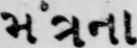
મંત્રના
